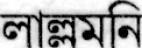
লাল্লমনি
